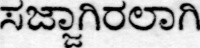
ಸಜ್ಜಾಗಿರಲಾಗಿ
